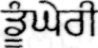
ਡੂੰਘੇਰੀ
